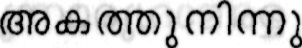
അകത്തുനിന്നു
